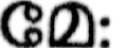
മേ:
